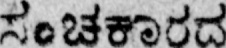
ಸಂಚಕಾರದ
